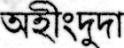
অহীংদুদা
